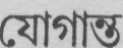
যোগান্ত
